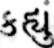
કહ્યું
